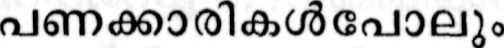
പണക്കാരികള്‍പോലും
